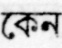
কেন
